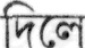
দিলে
